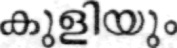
കുളിയും
